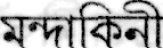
মন্দাকিনী
